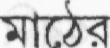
মাঠের
